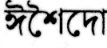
ঈশৈদো
